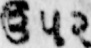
ઉપર
